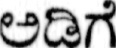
ಅಡಿಗೆ
